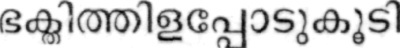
ഭക്തിത്തിളപ്പോടുകൂടി
